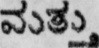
ಮತ್ತು
